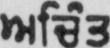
ਅਚਿੰਤ
